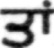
ਤਾਂ
